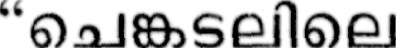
“ചെങ്കടലിലെ
